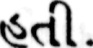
હતી.
